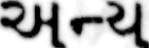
અન્ય
